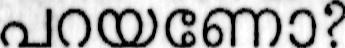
പറയണോ?
